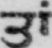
ਤਾਂ
